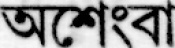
অশেংবা
